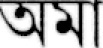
অমা
